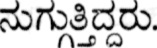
ನುಗ್ಗುತ್ತಿದ್ದರು.
